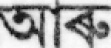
আৰু
